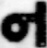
ન
